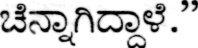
ಚೇನ್ನಾಗಿದ್ದಾಳೆ."
